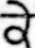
ਕੇ
